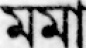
মমা
